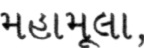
મહામૂલા,
